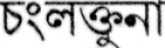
চংলক্তুনা
